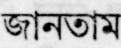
জানতাম
